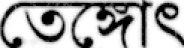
তেঙ্গোৎ
